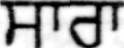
ਸਾਰਾ
